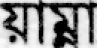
য়াম্না
